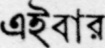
এইবার
